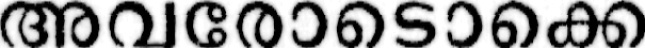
അവരോടൊക്കെ
